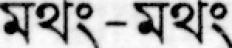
মথং-মথং
